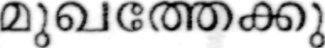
മുഖത്തേക്കു
